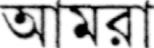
আমরা
